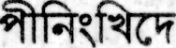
পীনিংখিদে
